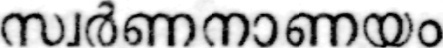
സ്വര്‍ണനാണയം
